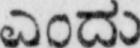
ಎಂದು
